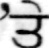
'ਤੇ
